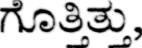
ಗೊತ್ತಿತ್ತು,
